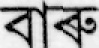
বাৰু
